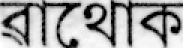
ৱাথোক
